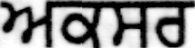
ਅਕਸਰ
